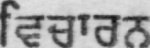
ਵਿਚਾਰਨ
